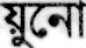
য়ুনো
